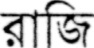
রাজি
